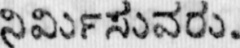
ನಿರ್ಮಿಸುವರು.
